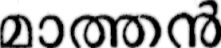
മാത്തന്‍
